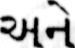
અને
